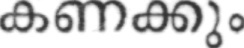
കണക്കും
